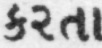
કરતા
